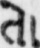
તો
